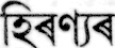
হিৰণ্যৰ
